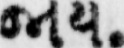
જાય.
